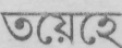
তয়েহে
